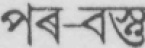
পৰ-বস্তু
